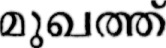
മുഖത്ത്
